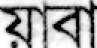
য়াবা
